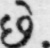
છે.
